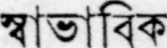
স্বাভাবিক
